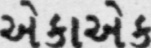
એકાએક
